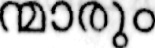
ന്മാരും
